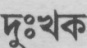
দুঃখক
